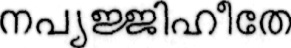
നപ്യജ്ജിഹീതേ
